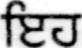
ਇਹ
